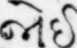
જોઈ
